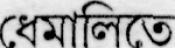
ধেমালিতে
